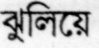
ঝুলিয়ে
